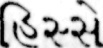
હિસ્સે
